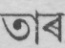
তাৰ
